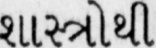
શાસ્ત્રોથી
